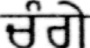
ਚੰਗੇ
